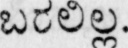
ಬರಲಿಲ್ಲ.
